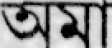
অমা
